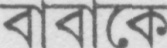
বাবাকে
